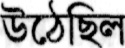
উঠেছিল
